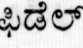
ಫಿಡೆಲ್
